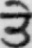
ਤੇ
